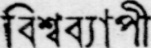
বিশ্বব্যাপী
